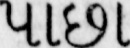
પાછા
